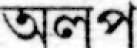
অলপ
